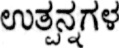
ಉತ್ಪನ್ನಗಳ
